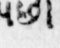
પછી
